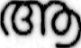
ആ
